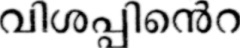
വിശപ്പിന്റെ
